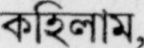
কহিলাম,
